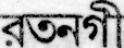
রতনগী
